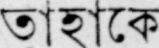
তাহাকে
